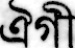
ঐগী
